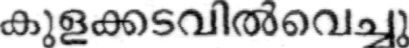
കുളക്കടവില്‍വെച്ചു
